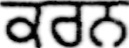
ਕਰਨ
